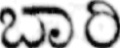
ಬಾರಿ
